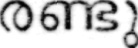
രണ്ടു
